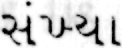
સંખ્યા
